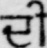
ਦੀ
